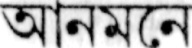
আনমনে
